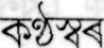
কণ্ঠস্বৰ
